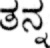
ತನ್ನ
